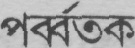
পৰ্ব্বতক
